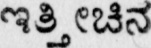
ಇತ್ತೀಚಿನ
